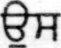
ਉਸ
